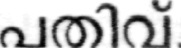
പതിവ്.
